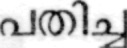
പതിച്ച
